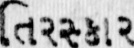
તિરસ્કાર
